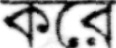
করে
